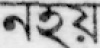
নহয়
